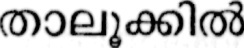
താലൂക്കില്‍
